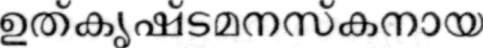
ഉത്കൃഷ്ടമനസ്കനായ
